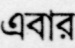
এবার
